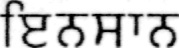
ਇਨਸਾਨ
